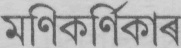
মণিকৰ্ণিকাৰ
